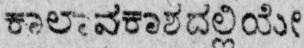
ಕಾಲಾವಕಾಶದಲ್ಲಿಯೇ
